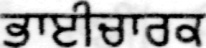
ਭਾਈਚਾਰਕ
